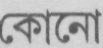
কোনো
